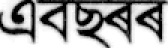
এবছৰৰ
